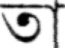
তা
